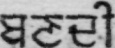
ਬਣਦੀ
